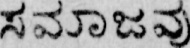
ಸಮಾಜವು
